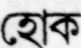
হোক
